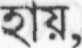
হায়,
